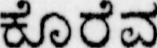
ಕೊರೆವ
